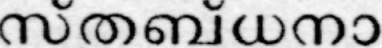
സ്തബ്ധനാ
